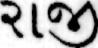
રાજી
